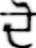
ਦੋ
